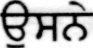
ਉਸਨੇ
